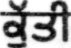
ਕੁੱਤੀ
